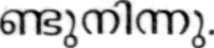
ണ്ടുനിന്നു.
